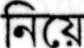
নিয়ে
